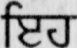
ਇਹ
